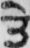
ਤੇ
